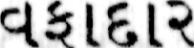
વફાદાર
